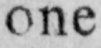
one
